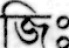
জিঃ
